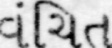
વંચિત
